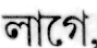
লাগে,
